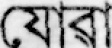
যোৱা
